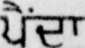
ਪੈਂਦਾ
